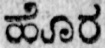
ಹೊರ
